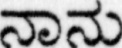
ನಾನು
